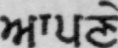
ਆਪਣੇ
